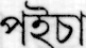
পইচা
